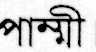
পাম্মী
